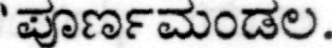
ಪೂರ್ಣಮಂಡಲ.
